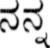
ನನ್ನ
